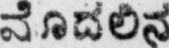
ಮೊದಲಿನ
